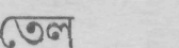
তেল
